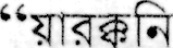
“য়ারক্কনি
